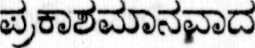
ಪ್ರಕಾಶಮಾನವಾದ
